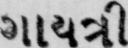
ગાયત્રી
